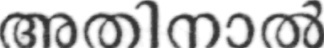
അതിനാല്‍
